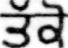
ਤੱਕੋ
